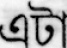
এটা
